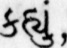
કહ્યું,
